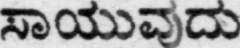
ಸಾಯುವುದು
